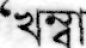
‘খম্বা
